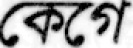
কেগে
